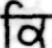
ਕਿ
